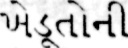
ખેડૂતોની
